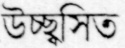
উচ্ছ্বসিত
